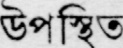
উপস্থিত
